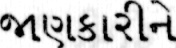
જાણકારીને
